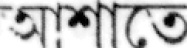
আশাতে
